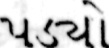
પડ્યો
